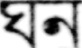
ঘন
